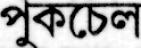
পুকচেল
